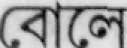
বোলে
